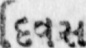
દિવસ
